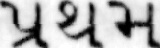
પ્રથમ
